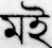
মই
